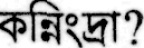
কন্নিংদ্রা?
